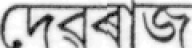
দেৱৰাজ
